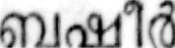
ബഷീര്‍
